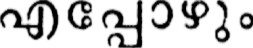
എപ്പോഴും
